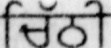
ਚਿੱਠੀ
